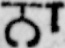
ਨਾ
